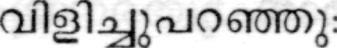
വിളിച്ചുപറഞ്ഞു:
